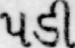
પડી
